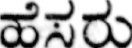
ಹೆಸರು
